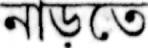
নাড়তে
